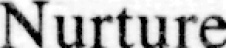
Nurture
